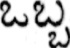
ಒಬ್ಬ
